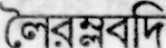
লৈরম্লবদি
